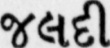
જલદી
